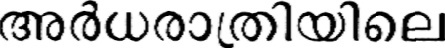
അര്‍ധരാത്രിയിലെ
